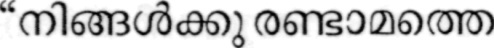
"നിങ്ങള്‍ക്കുരണ്ടാമത്തെ
